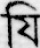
যি
